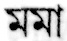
মমা
